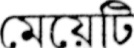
মেয়েটি
